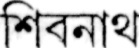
শিবনাথ
